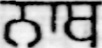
ਨਾਥ
